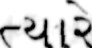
ત્યારે
